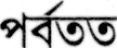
পর্বতত
